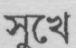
সুখে
